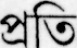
প্রতি
